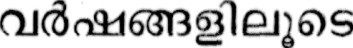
വര്‍ഷങ്ങളിലൂടെ
